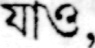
যাও,
